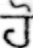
ਹੋ
